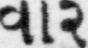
વાર
